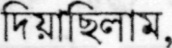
দিয়াছিলাম,
